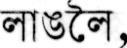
লাঙলৈ,
